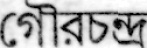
গৌরচন্দ্র
